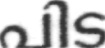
പിട
